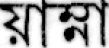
য়াম্না
